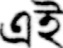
এই
